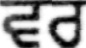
ਵਰ
